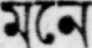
মনে
